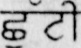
ਛੁੱਟੀ
